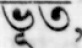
ভূত,
